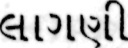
લાગણી
